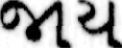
જાય
